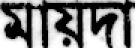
মায়দা
